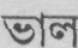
ভাল
